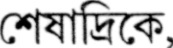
শেষাদ্রিকে,
